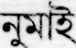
নুমাই
